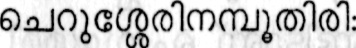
ചെറുശ്ശേരിനമ്പൂതിരി:
